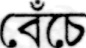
বেঁচে
